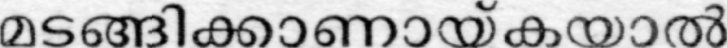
മടങ്ങിക്കാണായ്കയാല്‍
